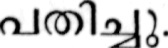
പതിച്ചു.
